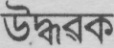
উদ্ধৱক
